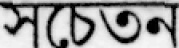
সচেতন
